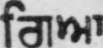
ਗਿਆ
